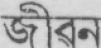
জীৱন
